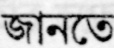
জানতে
